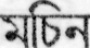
মচিন
